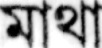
মাথা
